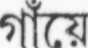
গাঁয়ে
